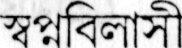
স্বপ্নবিলাসী
